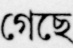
গেছে
